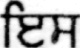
ਇਸ
